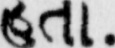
હતા.
